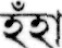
হঁহা
